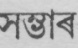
সম্ভাৰ
